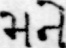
મને
